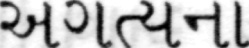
અગત્યના
